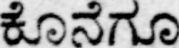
ಕೊನೆಗೂ
